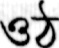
ওঠ
